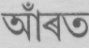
আঁৰত
